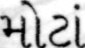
મોટાં
